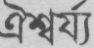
ঐশ্বৰ্য্য
